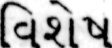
વિશેષ
